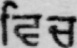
ਵਿਚ
